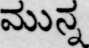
ಮುನ್ನ
